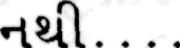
નથી....
